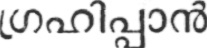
ഗ്രഹിപ്പാന്‍
